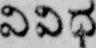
ವಿವಿಧ
